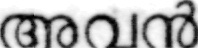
അവന്‍
